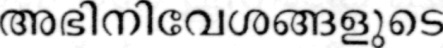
അഭിനിവേശങ്ങളുടെ
